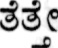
ತೆತ್ತೇ
